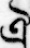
ঐ
